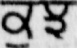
ਕੁਝ
